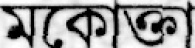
মকোক্তা
